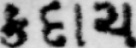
કદાચ
